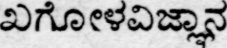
ಖಗೋಳವಿಜ್ಞಾನ
